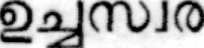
ഉച്ചസ്വര
